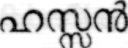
ഹസ്സന്‍
